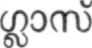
ഗ്ലാസ്
